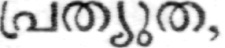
പ്രത്യുത,
